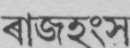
ৰাজহংস
